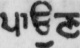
ਪਾਉਣ
